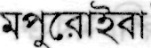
মপুরোইবা
